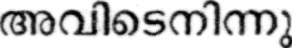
അവിടെനിന്നു
